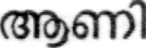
ആണി
